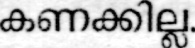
കണക്കില്ല.
